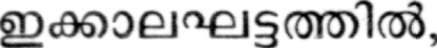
ഇക്കാലഘട്ടത്തില്‍,
